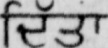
ਦਿੱਤਾ
